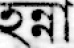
হন্না
